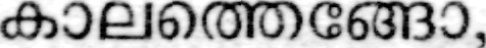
കാലത്തെങ്ങോ,
